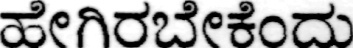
ಹೇಗಿರಬೇಕೆಂದು
